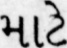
માટે
